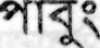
পাবুং
